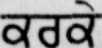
ਕਰਕੇ
